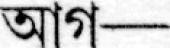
আগ-
